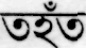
তহঁত
